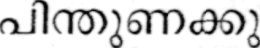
പിന്തുണക്കു
